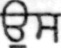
ਉਸ
